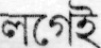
লগেই
